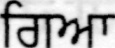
ਗਿਆ
